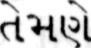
તેમણે
